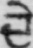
ਦੇ
